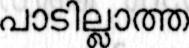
പാടില്ലാത്ത
